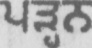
ਪੜ੍ਹਨ
